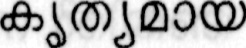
കൃത്യമായ
